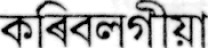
কৰিবলগীয়া
